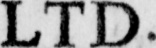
LTD.
